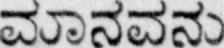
ಮಾನವನು
